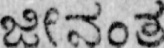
ಜೀವಂತ
